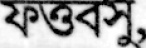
ফত্তবসু,
